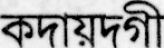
কদায়দগী
